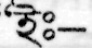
"ইঃ-
